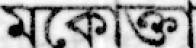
মকোক্তা
